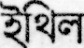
ইথিল
